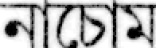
নাচোম
